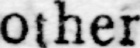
other
